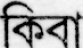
কিবা
